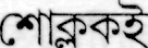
শোক্লকই
